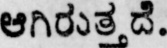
ಆಗಿರುತ್ತದೆ.
